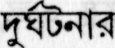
দুর্ঘটনার
